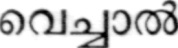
വെച്ചാല്‍
